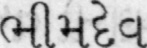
ભીમદેવ
